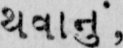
થવાનું,
